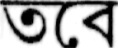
তবে
